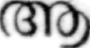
ആ
